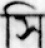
সি
